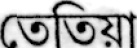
তেতিয়া
